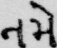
નમે
